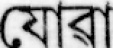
যোৱা
